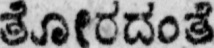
ತೋರದಂತೆ
